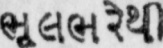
ભૂલભરેથી
